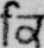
ਕਿ
